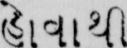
હોવાથી
